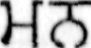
ਮਨ
